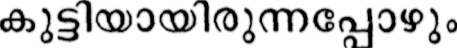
കുട്ടിയായിരുന്നപ്പോഴും
